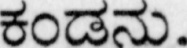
ಕಂಡನು.
